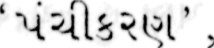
'પંચીકરણ',
